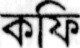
কফি
